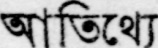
আতিথ্যে
